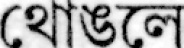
থোঙলে
